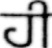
ਹੀ
